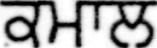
ਕਮਾਲ
